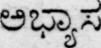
ಅಭ್ಯಾಸ
